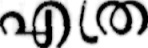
എത്ര
